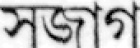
সজাগ
